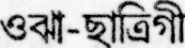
ওঝা-ছাত্রিগী
